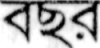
বছর
